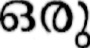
ഒരു
